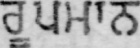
ਰੂਪਮਾਨ
